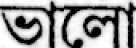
ভালো
